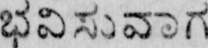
ಭವಿಸುವಾಗ
